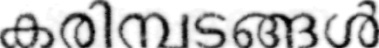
കരിമ്പടങ്ങള്‍
